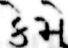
કેમે
